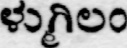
ಳ್ಮುಗಿಲಂ
